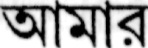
আমার
